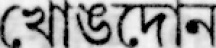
খোঙদোন
